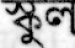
স্কুল
